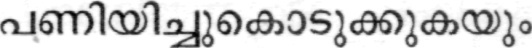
പണിയിച്ചുകൊടുക്കുകയും
